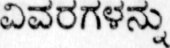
ವಿವರಗಳನ್ನು
